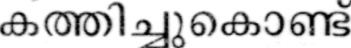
കത്തിച്ചുകൊണ്ട്
